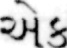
એક
